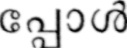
പ്പോള്‍
